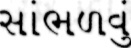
સાંભળવું
